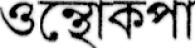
ওন্থোকপা
